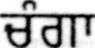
ਚੰਗਾ
